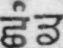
ਛੰਡ
